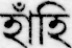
হাঁহি
